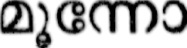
മൂന്നോ
